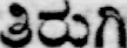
ತಿರುಗಿ
